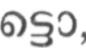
ട്ടൊ,
